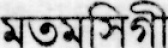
মতমসিগী
